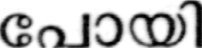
പോയി
